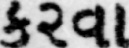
કરવા
